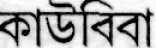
কাউবিবা
